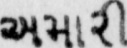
અમારી
